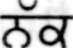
ਨੱਕ
